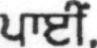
ਪਾਈਂ,
